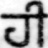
ਹੀ
